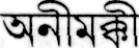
অনীমক্কী
